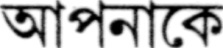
আপনাকে
